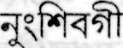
নুংশিবগী
